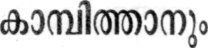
കാമ്പിത്താനും
